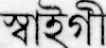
স্বাইগী
